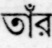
তাঁর
